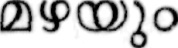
മഴയും
